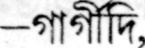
-গার্গীদি,
